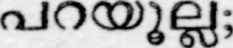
പറയൂല്ല;
